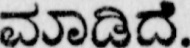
ಮಾಡಿದೆ.
